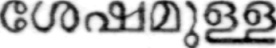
ശേഷമുള്ള
